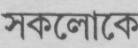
সকলোকে
